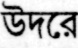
উদরে
